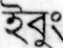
ইবুং
